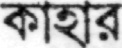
কাহার
